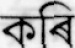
কৰি
